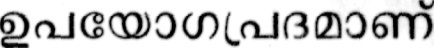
ഉപയോഗപ്രദമാണ്
